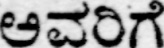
ಅವರಿಗೆ
